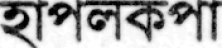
হাপলকপা
